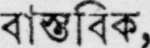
বাস্তবিক,
